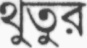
থুতুর
